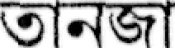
তানজা
